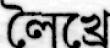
লৈখ্রে
